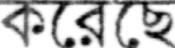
করেছে
